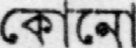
কোনো
